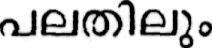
പലതിലും
